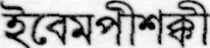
ইবেমপীশক্কী
